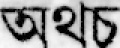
অথচ
